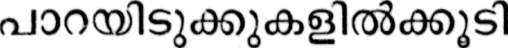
പാറയിടുക്കുകളില്‍ക്കൂടി
